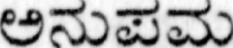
ಅನುಪಮ
